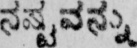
ನಷ್ಟವನ್ನು
